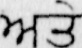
ਅਤੇ
